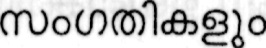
സംഗതികളും
